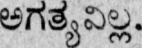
ಅಗತ್ಯವಿಲ್ಲ.
